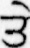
ਤੇ
